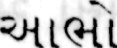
આભો
